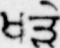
ਖੜੇ
